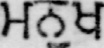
ਮਨੁਖ
